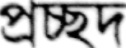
প্রচ্ছদ
